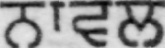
ਨਾਵਲ
